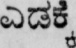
ಎಡಕ್ಕೆ
